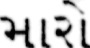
મારો
